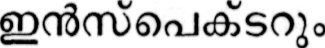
ഇന്‍സ്പെക്ടറും
